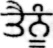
ਤੈਨੂੰ
